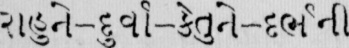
રાહુને-દુર્વા-કેતુને-દર્ભની
